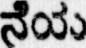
ನೆಯ
